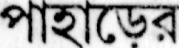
পাহাড়ের
